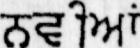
ਨਵੀਆਂ
